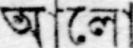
আলো
